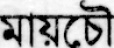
মায়চৌ
